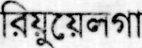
রিয়ুয়েলগা
